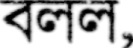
বলল,
